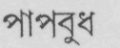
পাপবুধ
